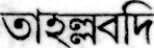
তাহল্লবদি
